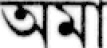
অমা
